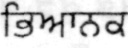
ਭਿਆਨਕ
